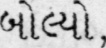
બોલ્યો,
